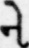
ને
